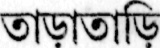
তাড়াতাড়ি
